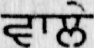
ਵਾਲੇ
